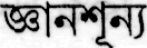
জ্ঞানশূন্য
